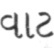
વાટ
